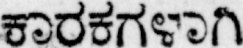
ಕಾರಕಗಳಾಗಿ
